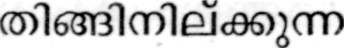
തിങ്ങിനില്ക്കുന്ന
